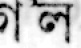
গ'ল
